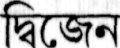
দ্বিজেন
